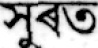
সুৰত
